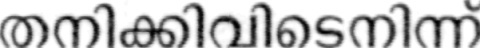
തനിക്കിവിടെനിന്ന്
